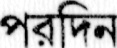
পরদিন
